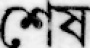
শেষ
